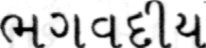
ભગવદીય
